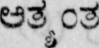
ಅತ್ಯಂತ
